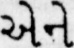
એને
